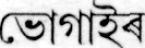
ভোগাইৰ
